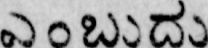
ಎಂಬುದು
